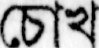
চোখ
